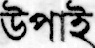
উপাই
